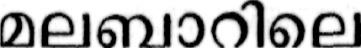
മലബാറിലെ
